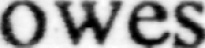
owes
